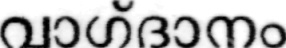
വാഗ്ദാനം
